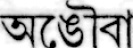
অঙৌবা
